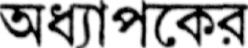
অধ্যাপকের
